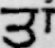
ਤਾਂ
